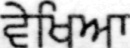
ਵੇਖਿਆ
